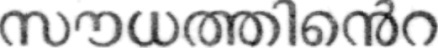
സൌധത്തിന്റെ
